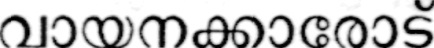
വായനക്കാരോട്
